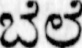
ಬೆಲೆ
